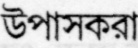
উপাসকরা
